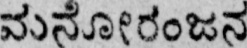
ಮನೋರಂಜನ
